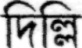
দিল্লি
